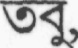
তবু,
